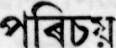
পৰিচয়
